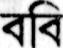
ববি
